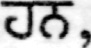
ਹਨ,
